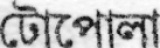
টোপোলা
